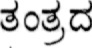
ತಂತ್ರದ
